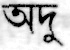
অদু
